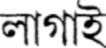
লাগাই
